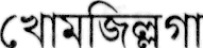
খোমজিল্লগা
